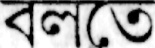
বলতে
